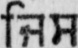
ਜਿਸ
